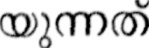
യുന്നത്
